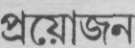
প্ৰয়োজন
